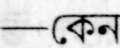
–কেন
